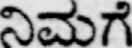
ನಿಮಗೆ
